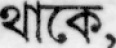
থাকে,
